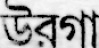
উরগা
